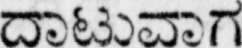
ದಾಟುವಾಗ
